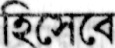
হিসেবে
